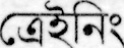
ত্রেইনিং
